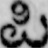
ಪಿ
